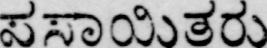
ಪಸಾಯಿತರು
